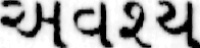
અવશ્ય
